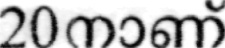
20നാണ്
